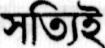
সত্যিই
